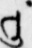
તું
